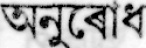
অনুৰোধ
